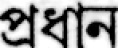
প্রধান
